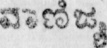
ವಾಣಿಜ್ಯ
